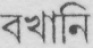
বখানি
